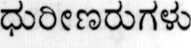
ಧುರೀಣರುಗಳು
